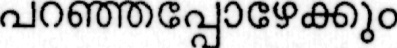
പറഞ്ഞപ്പോഴേക്കും
